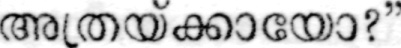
അത്രയ്ക്കായോ?”
